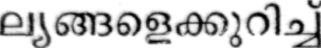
ല്യങ്ങളെക്കുറിച്ച്
